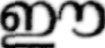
ഈ
